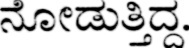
ನೋಡುತ್ತಿದ್ದ.
